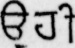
ਉਹੀ
